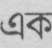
এক
